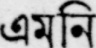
এমনি
